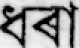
ধৰা
